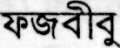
ফজবীবু
